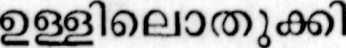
ഉള്ളിലൊതുക്കി
